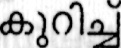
കുറിച്ച്
